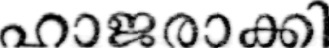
ഹാജരാക്കി
